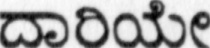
ದಾರಿಯೇ
